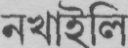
নখাইলি
